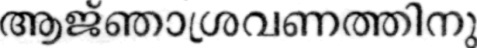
ആജ്ഞാശ്രവണത്തിനു
